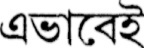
এভাবেই
